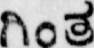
ಗಿಂತ
